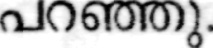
പറഞ്ഞു.
